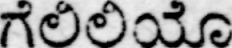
ಗೆಲಿಲಿಯೊ
